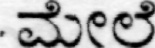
ಮೇಲೆ
